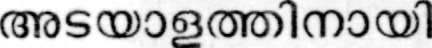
അടയാളത്തിനായി
